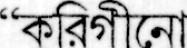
“করিগীনো
